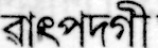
ৱাৎপদগী
